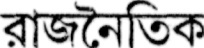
রাজনৈতিক
